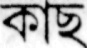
কাছ
